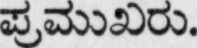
ಪ್ರಮುಖರು.
